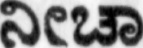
ನೀಚಾ
